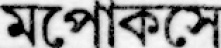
মপোকসে
